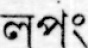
লপং
